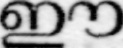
ഈ
